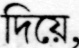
দিয়ে,
